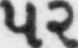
પર
